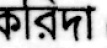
করিদা
